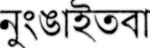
নুংঙাইতবা
